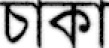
চাকা
